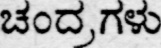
ಚಂದ್ರಗಳು
